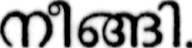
നീങ്ങി.
